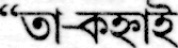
“তা-কহ্নাই
